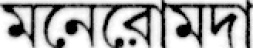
মনেরোমদা
